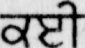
ਕਈ
